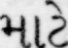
માટે
